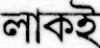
লাকই
